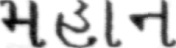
મહાન
